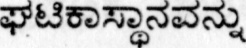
ಘಟಿಕಾಸ್ಥಾನವನ್ನು
